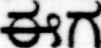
ಈಗ
